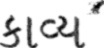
કાવ્ય
